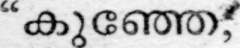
"കുഞ്ഞേ,
